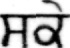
ਸਕੇ
